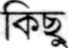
কিছু
